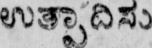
ಉತ್ಪಾದಿಸು
